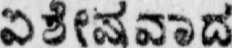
ವಿಶೇಷವಾದ
